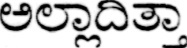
ಅಲ್ಲಾದಿತ್ತಾ
